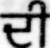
ਦੀ
